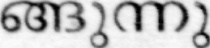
ങ്ങുന്നു
